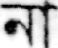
না
